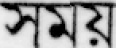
সময়
